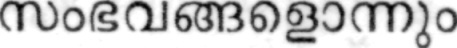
സംഭവങ്ങളൊന്നും
